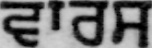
ਵਾਰਸ
